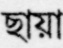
ছায়া
